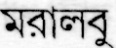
মরালবু
